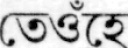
তেওঁহে
